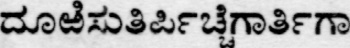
ದೂಱೆಸುತಿರ್ಪಿಚ್ಚೆಗಾರ್ತಿಗಾ
